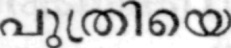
പുത്രിയെ
